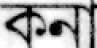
কনা
